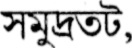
সমুদ্রতট,
